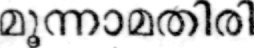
മൂന്നാമതിരി
